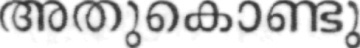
അതുകൊണ്ടു
